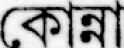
কোন্না
